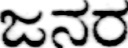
ಜನರ
